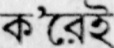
ক'রেই
